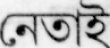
নেতাই
